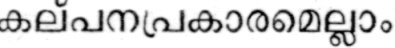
കല്പനപ്രകാരമെല്ലാം
